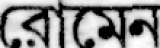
রোমেন
